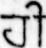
ਹੀ
